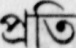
প্রতি
